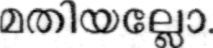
മതിയല്ലോ.
